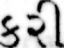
કરી
